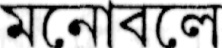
মনোবলে
